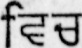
ਵਿਚ
